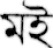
মই
